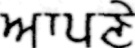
ਆਪਣੇ
